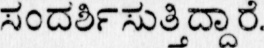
ಸಂದರ್ಶಿಸುತ್ತಿದ್ದಾರೆ.
